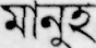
মানুহ
